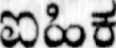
ಐಹಿಕ
